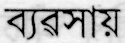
ব্যৱসায়
